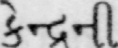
કેન્દ્રની
